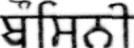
ਬੌਸਿਨੀ
